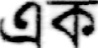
এক
